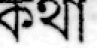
কথা
